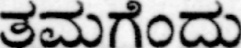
ತಮಗೆಂದು
